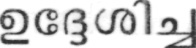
ഉദ്ദേശിച്ച
